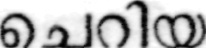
ചെറിയ
